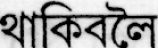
থাকিবলৈ
